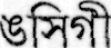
ঙসিগী
